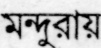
মন্দুরায়
